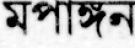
মপাঙ্গল
